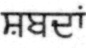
ਸ਼ਬਦਾਂ
